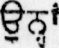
ਉਨ੍ਹਾਂ
